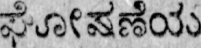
ಘೋಷಣೆಯ
